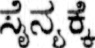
ಸೈನ್ಯಕ್ಕೆ
